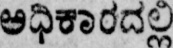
ಅಧಿಕಾರದಲ್ಲಿ
